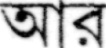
আর
